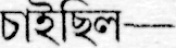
চাইছিল-
